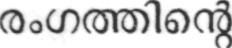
രംഗത്തിന്റെ
